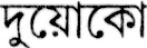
দুয়োকো
